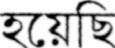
হয়েছি
